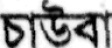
চাউবা
